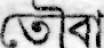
তৌবা
